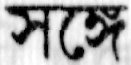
সঙ্গে
